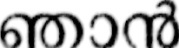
ഞാന്‍
